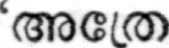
‘അത്രേ
